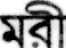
মরী
